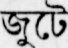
জুটে
